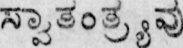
ಸ್ವಾತಂತ್ರ್ಯವು
